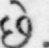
છે.
